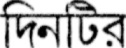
দিনটির
